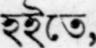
হইতে,
